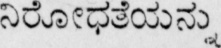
ನಿರೋಧತೆಯನ್ನು
